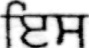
ਇਸ
